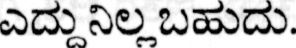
ಎದ್ದುನಿಲ್ಲಬಹುದು.
